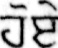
ਹੋਏ
